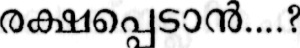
രക്ഷപ്പെടാന്‍....?
